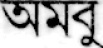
অমবু
